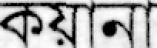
কয়ানা
